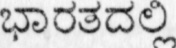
ಭಾರತದಲ್ಲಿ
